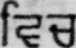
ਵਿਚ
